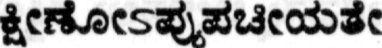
ಕ್ಷೀಣೋsಪ್ಯುಪಚೀಯತೇ
